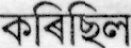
কৰিছিল
